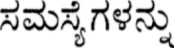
ಸಮಸ್ಯೆಗಳನ್ನು
